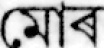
মোৰ
